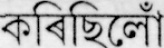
কৰিছিলোঁ
